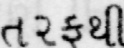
તરફથી
